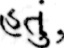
હતું,
